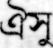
ঐসু
